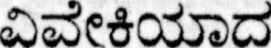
ವಿವೇಕಿಯಾದ
